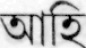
আহি
